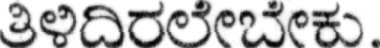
ತಿಳಿದಿರಲೇಬೇಕು.
